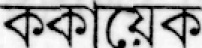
ককায়েক
